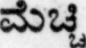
ಮೆಚ್ಚಿ
